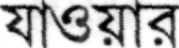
যাওয়ার
